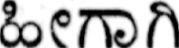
ಹೀಗಾಗಿ
